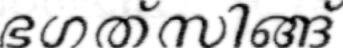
ഭഗത്സിങ്ങ്
